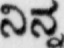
ನಿನ್ನ
